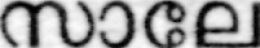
സാലേ
